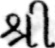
શ્રી
